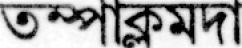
তম্পাক্লমদা
